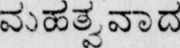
ಮಹತ್ವವಾದ
